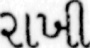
રાખી
